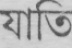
যাতি
